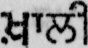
ਖ਼ਾਲੀ
